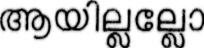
ആയില്ലല്ലോ
